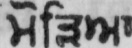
ਮੋੜਿਆ
